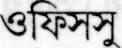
ওফিসসু
